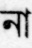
না
